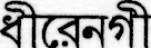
ধীরেনগী
